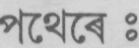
পথেৰেঃ
